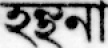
হন্থনা
